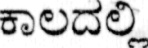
ಕಾಲದಲ್ಲಿ
